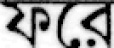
ফরে
